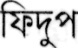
ফিদুপ
